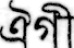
ঐগী
